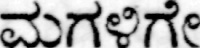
ಮಗಳಿಗೇ
